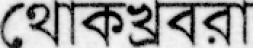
থোকখ্রবরা
